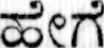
ಹೇಗೆ
